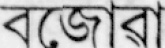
বজোৱা
